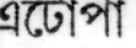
এটোপা
